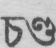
চণ্ড
